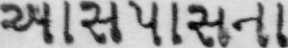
આસપાસના
